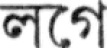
লগে
